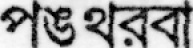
পঙথরবা
